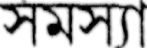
সমস্যা
